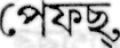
পেফছ্,
